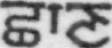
ਛਾਣ
